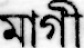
মাগী
